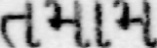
તમામ
